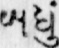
બધું
